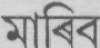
মাৰিব
